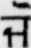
ਜੋ
